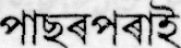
পাছৰপৰাই
